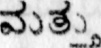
ಮತ್ತು
